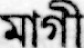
মাগী
